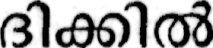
ദിക്കില്‍
